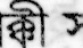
ক্কী
